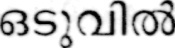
ഒടുവില്‍
